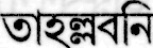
তাহল্লবনি
